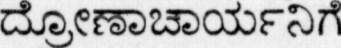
ದ್ರೋಣಾಚಾರ್ಯನಿಗೆ
